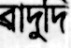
ৱাদুদি
